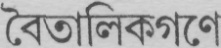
বৈতালিকগণে
